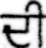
ਦੀ
